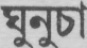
ঘুনুচা
